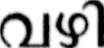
വഴി
